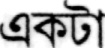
একটা
